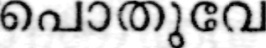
പൊതുവേ
